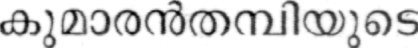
കുമാരന്‍തമ്പിയുടെ
